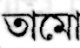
তামো
